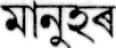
মানুহৰ
